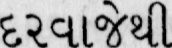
દરવાજેથી
